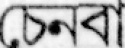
চেনবা
